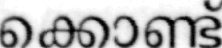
ക്കൊണ്ട്
